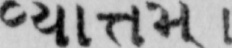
વ્યાત્તમ્|
